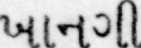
ખાનગી
